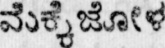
ಮೆಕ್ಕೆಜೋಳ
